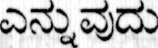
ಎನ್ನುವುದು
